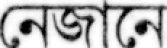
নেজানে
